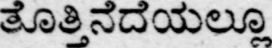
ತೊತ್ತಿನೆದೆಯಲ್ಲೂ
